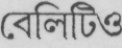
বেলিটিও
